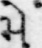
મેં
